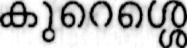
കുറെശ്ശെ
